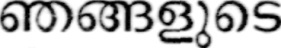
ഞങ്ങളുടെ
